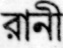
রানী
